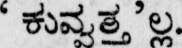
‘ಕುವ್ವತ್ತ’ಲ್ಲ.
